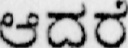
ಆದರೆ
